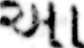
આ
